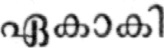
ഏകാകി
